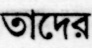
তাদের
